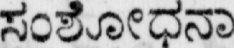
ಸಂಶೋಧನಾ
